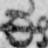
ಈ
